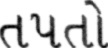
તપતો
